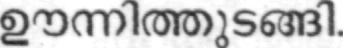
ഊന്നിത്തുടങ്ങി.
